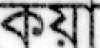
কয়া
